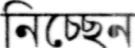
নিচ্ছেন
